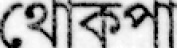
থোকপা
